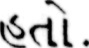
હતો.
